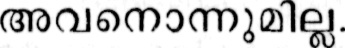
അവനൊന്നുമില്ല.
